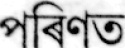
পৰিণত
